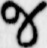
જ
